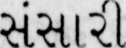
સંસારી
